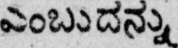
ಎಂಬುದನ್ನು
